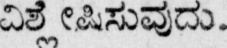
ವಿಶ್ಲೇಷಿಸುವುದು.
